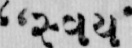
“સ્વયં
